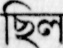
ছিল
